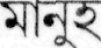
মানুহ
